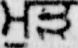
ਮੁੜ
